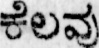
ಕೆಲವು
